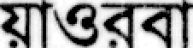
য়াওরবা
